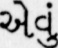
એવું
